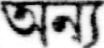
অন্য
